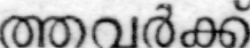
ത്തവര്‍ക്ക്
